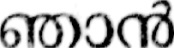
ഞാന്‍
